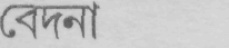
বেদনা
